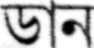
ডান
